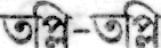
তপ্লি-তপ্লি
